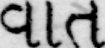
વાત
